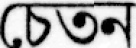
চেতন
